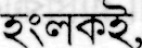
হংলকই,
